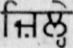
ਜ਼ਿਲ੍ਹੇ
